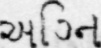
અગ્નિ
